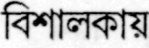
বিশালকায়
